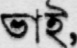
ভাই,
